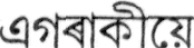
এগৰাকীয়ে
